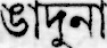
ঙাদুনা
